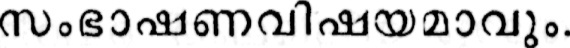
സംഭാഷണവിഷയമാവും.
